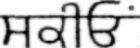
ਸਕੀਓਂ
